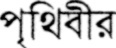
পৃথিবীর
